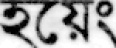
হয়েং
